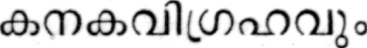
കനകവിഗ്രഹവും
